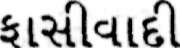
ફાસીવાદી
